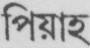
পিয়াহ
